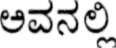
ಅವನಲ್ಲಿ
